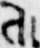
તો
